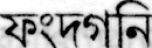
ফংদগনি
